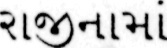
રાજીનામાં
